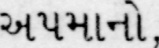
અપમાનો,
